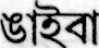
ঙাইবা
